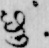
છું.
